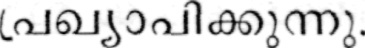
പ്രഖ്യാപിക്കുന്നു.
